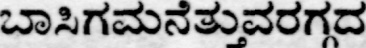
ಬಾಸಿಗಮನೆತ್ತುವರಗ್ಗದ
